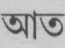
আত
